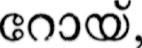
റോയ്,
